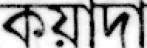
কয়াদা
